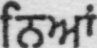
ਨਿਆਂ
